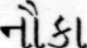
નૌકા
